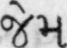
જેમ
